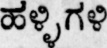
ಹಳ್ಳಿಗಳಿ
